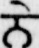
ਨੇ
